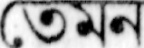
তেমন
